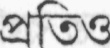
প্রতিও
